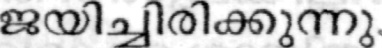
ജയിച്ചിരിക്കുന്നു.
